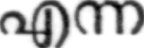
എന്ന
